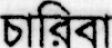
চারিবা
